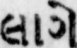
લાગે
